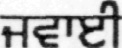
ਜਵਾਈ
